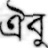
ঐবু
